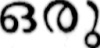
ഒരു
